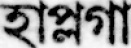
হাপ্লগা
